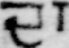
ਦਾ
